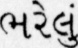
ભરેલું
